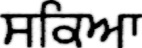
ਸਕਿਆ
